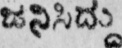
ಜನಿಸಿದ್ದು
